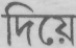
দিয়ে
